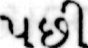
પછી
